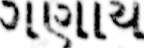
ગણાય
